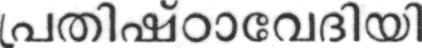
പ്രതിഷ്ഠാവേദിയി
